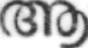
ആ
